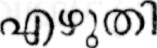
എഴുതി
